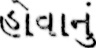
હોવાનું
